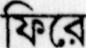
ফিরে
